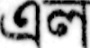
এল
